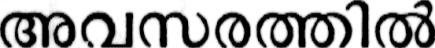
അവസരത്തില്‍
